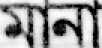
মানা
